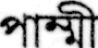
পাম্মী
